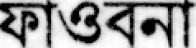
ফাওবনা
